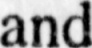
and
